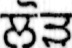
ਲੋੜ
